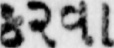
કરવા
